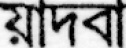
য়াদবী
